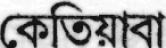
কেতিয়াবা
